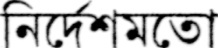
নির্দেশমতো
